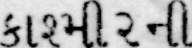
કાશ્મીરની
